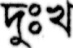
দুঃখ
